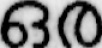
ഒര
